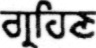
ਗ੍ਰਹਿਣ
